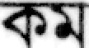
কম
